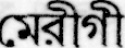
মেরীগী
